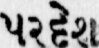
પરદેશ
